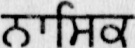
ਨਾਸਿਕ
